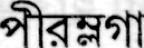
পীরম্লগা
